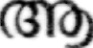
ആ
